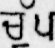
ਚੁੱਪ
